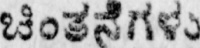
ಚಿಂತನೆಗಳು
